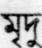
মৃদু
